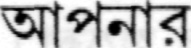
আপনার
